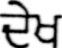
ਦੇਖ
